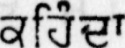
ਕਹਿੰਦਾ
